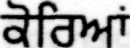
ਕੋਰਿਆਂ
